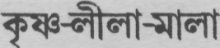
কৃষ্ণ-লীলা-মালা
